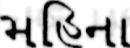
મહિના
